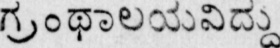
ಗ್ರಂಥಾಲಯವಿದ್ದು
